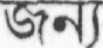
জন্য
